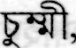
চুম্মী,
